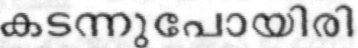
കടന്നുപോയിരി
